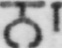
ਨਾ
